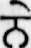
ਨੇ
